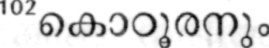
102കൊഠൂരനും
